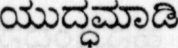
ಯುದ್ಧಮಾಡಿ
